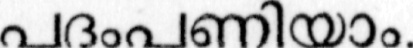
പദംപണിയാം.
